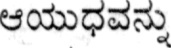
ಆಯುಧವನ್ನು
